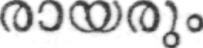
രായരും
